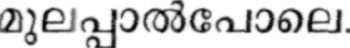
മുലപ്പാല്‍പോലെ.
